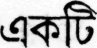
একটি
